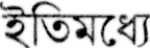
ইতিমধ্যে
